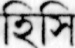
হিসি
